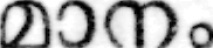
മാനം
